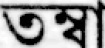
তম্বা
